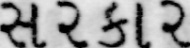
સરકાર
